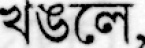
খঙলে,
